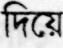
দিয়ে
